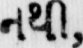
નથી
